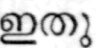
ഇതു
